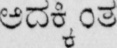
ಅದಕ್ಕಿಂತ
